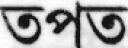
তপত
